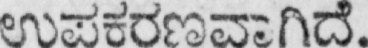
ಉಪಕರಣವಾಗಿದೆ.
